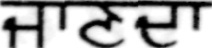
ਜਾਣਦਾ
